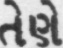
તેણે
